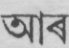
আৰ
